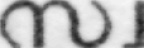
സ്വ
